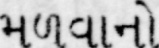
મળવાનો
